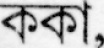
ককা,
